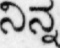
ನಿನ್ನ
